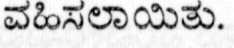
ವಹಿಸಲಾಯಿತು.
